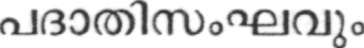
പദാതിസംഘവും
